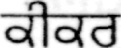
ਕੀਕਰ
